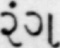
રંગ
